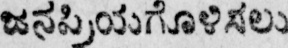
ಜನಪ್ರಿಯಗೊಳಿಸಲು
